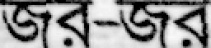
জর-জর
